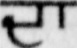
ਦਾ
